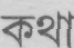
কথা
